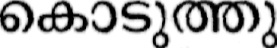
കൊടുത്തു
